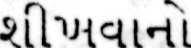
શીખવાનો
